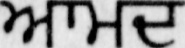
ਆਮਦ
